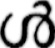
ള്‍
